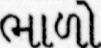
ભાળો
